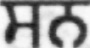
ਸਨ
